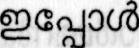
ഇപ്പോള്‍
